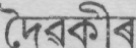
দৈৱকীৰ
